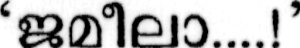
'ജമീലാ....!'
